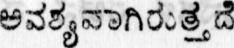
ಅವಶ್ಯವಾಗಿರುತ್ತದೆ.
